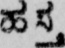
ಹಸ್ತ
